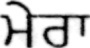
ਮੇਰਾ
